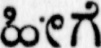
ಹೀಗೆ
